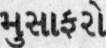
મુસાફરો
